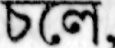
চলে,
